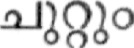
ചുറ്റും
